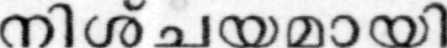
നിശ്ചയമായി
